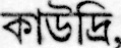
কাউদ্রি,
